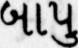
બાપુ
